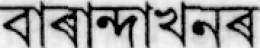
বাৰান্দাখনৰ
